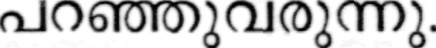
പറഞ്ഞുവരുന്നു.
